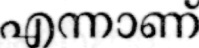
എന്നാണ്
